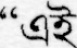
"এই
